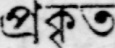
প্রকৃত
